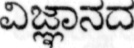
ವಿಜ್ಞಾನದ
